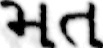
મત
